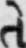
તે
